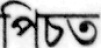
পিচত
